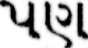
પણ
